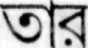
তার
